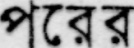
পরের
